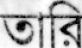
তারি
